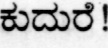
ಕುದುರೆ!
